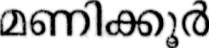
മണിക്കൂര്‍
